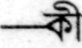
–কী
